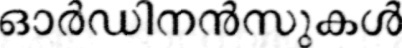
ഓര്‍ഡിനന്‍സുകള്‍
